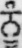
ਨੂੰ
